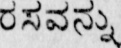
ರಸವನ್ನು
